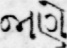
જાણે
